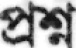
প্ৰশ্ন
